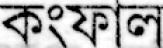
কংফাল
